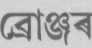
ব্ৰোঞ্জৰ
